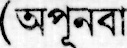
(অপূনবা
